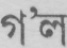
গ'ল
